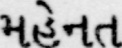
મહેનત
